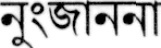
নুংজাননা
